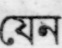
যেন
